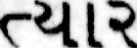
ત્યાર
